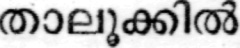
താലൂക്കില്‍
